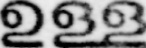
ഉളള
